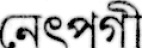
নেৎপগী
